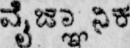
ವೈಜ್ಞಾನಿಕ
